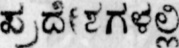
ಪ್ರದೇಶಗಳಲ್ಲಿ
